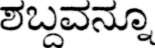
ಶಬ್ದವನ್ನೂ
